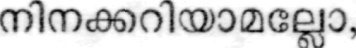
നിനക്കറിയാമല്ലോ,
